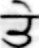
ਤੇ
